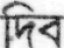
দিব
